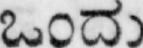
ಒಂದು
